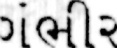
ગંભીર
